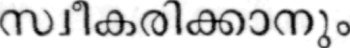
സ്വീകരിക്കാനും
